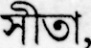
সীতা,
